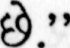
છે."
